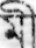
মী
